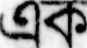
এক
